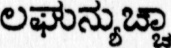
ಲಘುನ್ಯುಚ್ಚಾ
